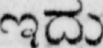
ಇದು
